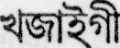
খজাইগী
